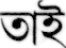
তাই
